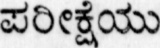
ಪರೀಕ್ಷೆಯು
